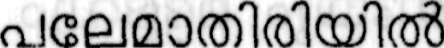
പലേമാതിരിയില്‍
